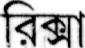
রিক্সা
